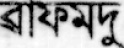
ৱাফমদু
